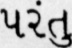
પરંતુ
